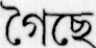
গৈছে
